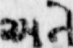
અને
